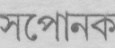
সপোনক
